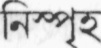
নিস্পৃহ
